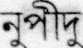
নুপীদু
